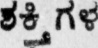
ಶಕ್ತಿಗಳ
